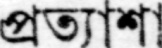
প্রত্যাশা
